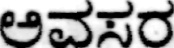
ಅವಸರ
